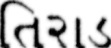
તિરાડ
